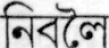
নিবলৈ
